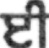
ਈ
